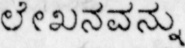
ಲೇಖನವನ್ನು
